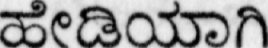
ಹೇಡಿಯಾಗಿ
